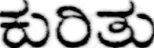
ಕುರಿತು
